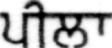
ਪੀਲਾ
